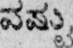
ವಷ್ಟು
